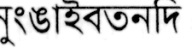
নুংঙাইবতনদি
